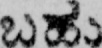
ಬಹು
